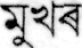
মুখৰ
